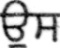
ਉਸ
